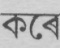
কৰে
